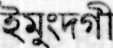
ইমুংদগী
